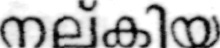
നല്കിയ
